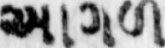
આગળ
